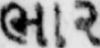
ભાર
